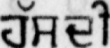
ਹੱਸਦੀ
